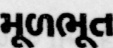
મૂળભૂત
